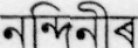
নন্দিনীৰ
